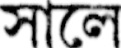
সালে
